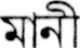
মানী
